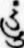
હું
